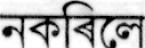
নকৰিলে
